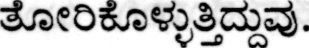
ತೋರಿಕೊಳ್ಳುತ್ತಿದ್ದುವು.
